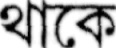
থাকে
